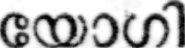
യോഗി
